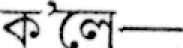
ক'লে-
